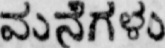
ಮನೆಗಳು
